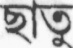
ছাতু
